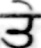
ਤੇ
